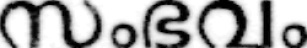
സംഭവം
